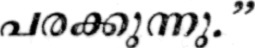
പരക്കുന്നു."
